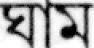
ঘাম
